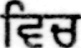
ਵਿਚ
